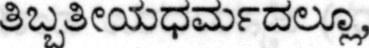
ತಿಬ್ಬತೀಯಧರ್ಮದಲ್ಲೂ,
